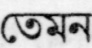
তেমন
